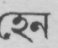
হেন
